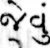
જેવું
